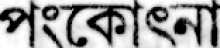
পংকোৎনা
